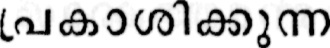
പ്രകാശിക്കുന്ന
